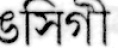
ঙসিগী
